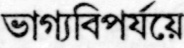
ভাগ্যবিপর্যয়ে
